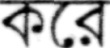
করে
